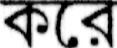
করে
